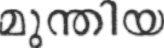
മുന്തിയ
